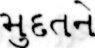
મુદતને
